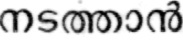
നടത്താന്‍
